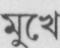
মুখে
